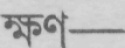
ক্ষণ-
